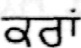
ਕਰਾਂ
